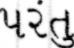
પરંતુ
